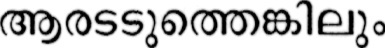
ആരടടുത്തെങ്കിലും
